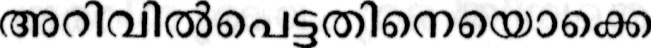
അറിവില്‍പെട്ടതിനെയൊക്കെ
